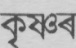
কৃষ্ণৰ
